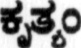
ಕೃತ್ಯಂ
